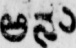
ಅನು
